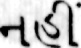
નહીં
